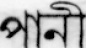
পানী
